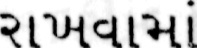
રાખવામાં
